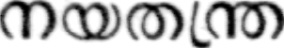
നയതന്ത്ര
